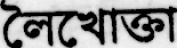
লৈখোক্তা
